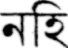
নহি
